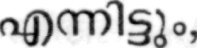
എന്നിട്ടും,
